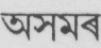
অসমৰ
